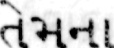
તેમના
